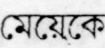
মেয়েকে
